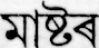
মাষ্টৰ
